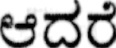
ಆದರೆ
